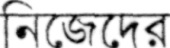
নিজেদের
